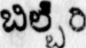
ಬೆಲ್ಬೆರಿ
